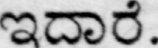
ಇದಾರೆ.
